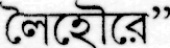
লৈহৌরে”
